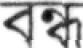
বন্ধ
